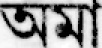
অমা
